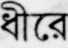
ধীরে
